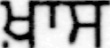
ਖ਼ਾਸ
